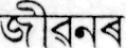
জীৱনৰ
